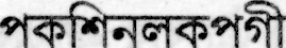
পকশিনলকপগী
